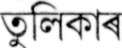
তুলিকাৰ
